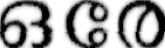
ഒരേ
